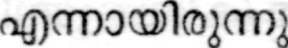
എന്നായിരുന്നു
